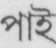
পাই
